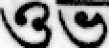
ওফ
